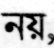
নয়,
